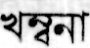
খম্বনা
